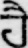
ਹੈ
